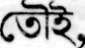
তৌই,
